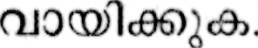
വായിക്കുക.
